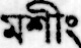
মশীং
